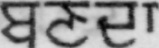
ਬਣਦਾ
